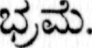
ಭ್ರಮೆ.
